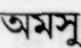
অমসু
